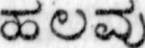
ಹಲವು
